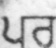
ਪਰ
